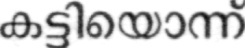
കട്ടിയൊന്ന്
